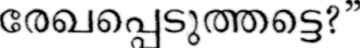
രേഖപ്പെടുത്തട്ടെ?"
